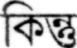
কিন্তু
